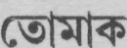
তোমাক
